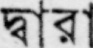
দ্বারা
